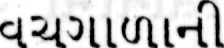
વચગાળાની
